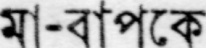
মা-বাপকে
